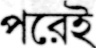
পরেই
